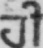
ਹੀ
